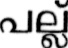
പല്ല്
